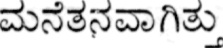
ಮನೆತನವಾಗಿತ್ತು
